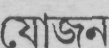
যোজন
